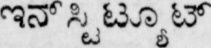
ಇನ್‌ಸ್ಟಿಟ್ಯೂಟ್
